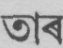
তাৰ
